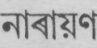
নাৰায়ণ
